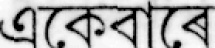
একেবাৰে
